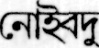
নোইবদু
